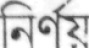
নির্ণয়
